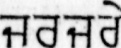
ਜਰਜਰੇ
